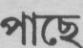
পাছে
